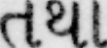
તથા
